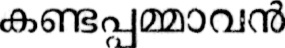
കണ്ടപ്പമ്മാവന്‍
